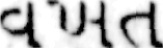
વખત
